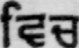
ਵਿਚ
